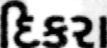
દિકરા
